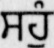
ਸਹੁੰ
